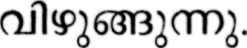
വിഴുങ്ങുന്നു.
